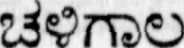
ಚಳಿಗಾಲ
